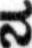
ನ
